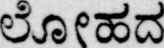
ಲೋಹದ
